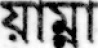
য়াম্না
